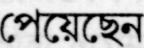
পেয়েছেন
